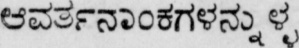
ಆವರ್ತನಾಂಕಗಳನ್ನುಳ್ಳ
